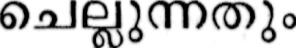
ചെല്ലുന്നതും
